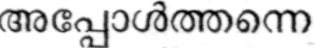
അപ്പോള്‍ത്തന്നെ
